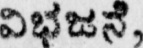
ವಿಭಜನೆ,
